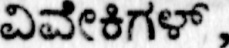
ವಿವೇಕಿಗಳ್,
